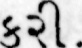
કરી.
